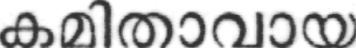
കമിതാവായ
